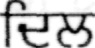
ਦਿਲ
